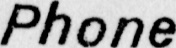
Phone
